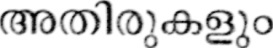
അതിരുകളും
